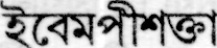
ইবেমপীশক্তা
